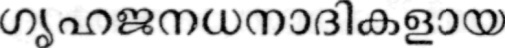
ഗൃഹജനധനാദികളായ
